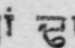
ਢਾ
